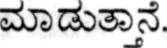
ಮಾಡುತ್ತಾನೆ.
